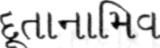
દૂતાનામિવ
